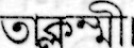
তাক্লম্মী।
